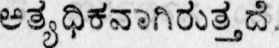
ಅತ್ಯಧಿಕವಾಗಿರುತ್ತದೆ.
